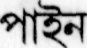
পাইন
